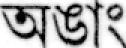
অঙাং
